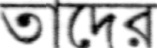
তাদের
